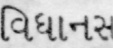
વિધાનસભાઓમાં
